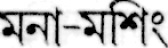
মনা-মশিং
